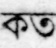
কত
